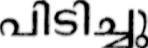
പിടിച്ചു
